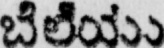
ಬೆಲೆಯು
